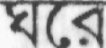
ঘরে
